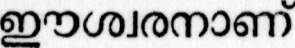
ഈശ്വരനാണ്
